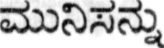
ಮುನಿಸನ್ನು
